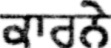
ਕਾਰਨੇ
